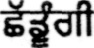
ਛੱਡੂੰਗੀ
